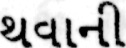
થવાની
